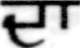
ਦਾ
